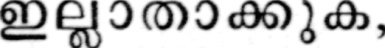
ഇല്ലാതാക്കുക,
